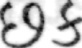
છક
